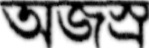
অজস্র
